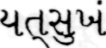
યત્સુખં
